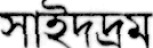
সাইদদ্রম
